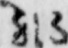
કોડ
